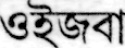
ওইজবা
